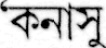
‘কনাসু
